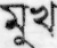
মুখ
